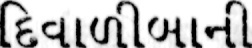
દિવાળીબાની
